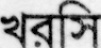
খরসি
